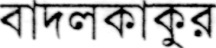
বাদলকাকুর
